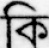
কি
